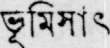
ভূমিসাৎ
